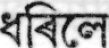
ধৰিলে
